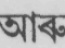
আৰু
